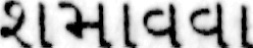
શમાવવા
